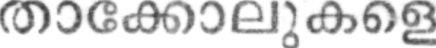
താക്കോലുകളെ
